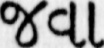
જવા
